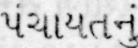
પંચાયતનું
